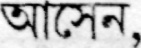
আসেন,
